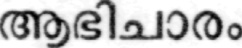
ആഭിചാരം
